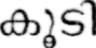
കൂടി
